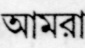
আমরা
